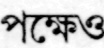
পক্ষেও
